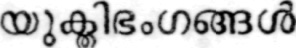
യുക്തിഭംഗങ്ങള്‍
